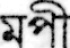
মপী
